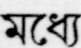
মধ্যে
